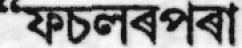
"ফচলৰপৰা
